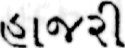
હાજરી
